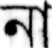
না
